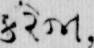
કરેજા,
